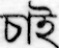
চাই
